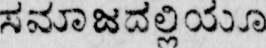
ಸಮಾಜದಲ್ಲಿಯೂ
